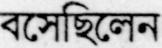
বসেছিলেন
